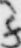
કે
